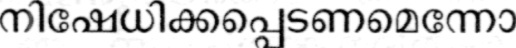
നിഷേധിക്കപ്പെടണമെന്നോ
